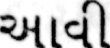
આવી
